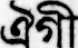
ঐগী
